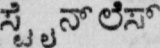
ಸ್ಟೈನ್‌ಲೆಸ್
